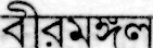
বীরমঙ্গল
